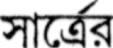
সার্ত্রের
